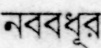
নববধূর
